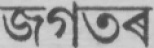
জগতৰ
